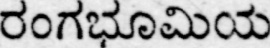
ರಂಗಭೂಮಿಯ
